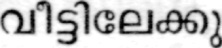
വീട്ടിലേക്കു
